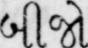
બીજો
